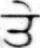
ਤੇ
